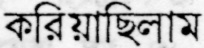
করিয়াছিলাম
